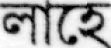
লাহে
